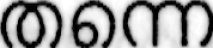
തന്നെ
